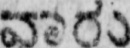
ವಾರು
